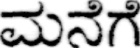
ಮನೆಗೆ
